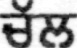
ਚੱਲ
